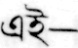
এই-
